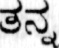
ತನ್ನ
